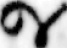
જ
